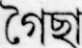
গৈছা
